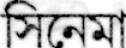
সিনেমা
